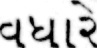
વધારે
